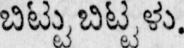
ಬಿಟ್ಟುಬಿಟ್ಟಳು.
